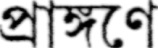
প্রাঙ্গণে
